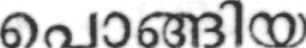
പൊങ്ങിയ
